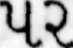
પર
